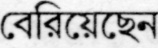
বেরিয়েছেন
